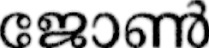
ജോണ്‍
